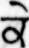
ਕੇ
